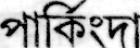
পার্কিংদা
